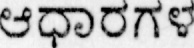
ಆಧಾರಗಳ
